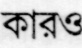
কারও
